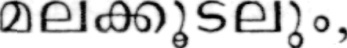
മലക്കൂടലും,
